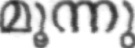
മൂന്നു
